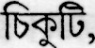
চিকুটি,
